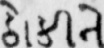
ઠોકીને
